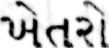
ખેતરો
